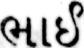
ભાઈ
